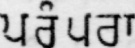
ਪਰੰਪਰਾ
